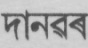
দানৱৰ
